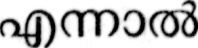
എന്നാല്‍
